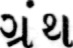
ગ્રંથ
